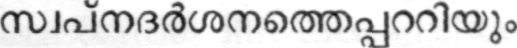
സ്വപ്നദര്‍ശനത്തെപ്പററിയും
